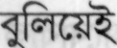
বুলিয়েই
